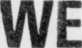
WE
